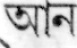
আন
